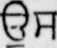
ਉਸ
